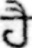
ਹੈ
